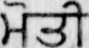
ਮੋਤੀ
